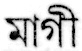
মাগী
